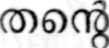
തന്റെ
